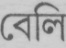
বেলি
